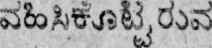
ವಹಿಸಿಕೊಟ್ಟಿರುವ
